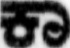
ಕಾ
